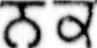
ਨਕ
